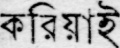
করিয়াই
